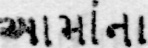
આમાંના
